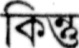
কিন্তু
